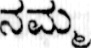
ನಮ್ಮ
